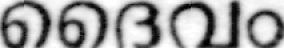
ദൈവം
